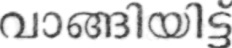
വാങ്ങിയിട്ട്
